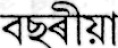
বছৰীয়া
